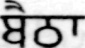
ਬੈਠਾ
